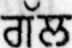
ਗੱਲ
